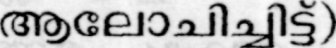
ആലോചിച്ചിട്ട്)
